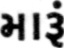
મારૂં
